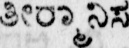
ತೇರ್ಮಾನಿಸ
